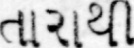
તારાથી
